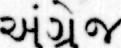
અંગ્રેજ
